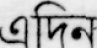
এদিন
